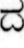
ದ
